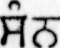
ਸੰਨ
